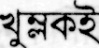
খুম্লকই
